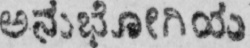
ಅನುಭೋಗಿಯ
